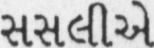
સસલીએ
